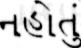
નહોતું
